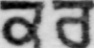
ਕਰ
